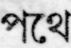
পথে
